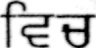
ਵਿਚ
